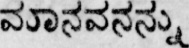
ಮಾನವನನ್ನು
